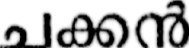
ചക്കന്‍
